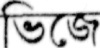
ভিজে
